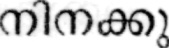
നിനക്കു
